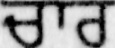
ਚਾਰ
